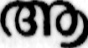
ആ
